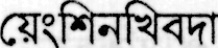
য়েংশিনখিবদা
